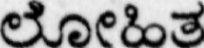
ಲೋಹಿತ
